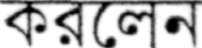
করলেন
